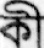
কী
